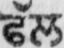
ਫੱਲ
